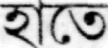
হাতে
